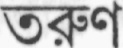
তরুণ
